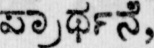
ಪ್ರಾರ್ಥನೆ,
